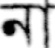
না
